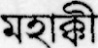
মহাক্কী
